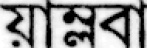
য়াম্লবা
